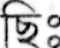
ছিঃ
